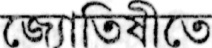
জ্যোতিষীতে
